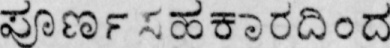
ಪೂರ್ಣಸಹಕಾರದಿಂದ
